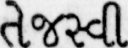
તેજસ્વી
